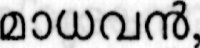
മാധവന്‍,
